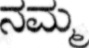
ನಮ್ಮ
